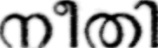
നീതി
